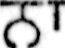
ਨਾ
